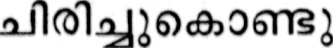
ചിരിച്ചുകൊണ്ടു
